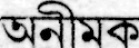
অনীমক
